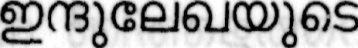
ഇന്ദുലേഖയുടെ
